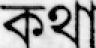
কথা
